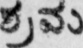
ಶ್ರಮ
